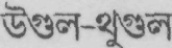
উগুল-থুগুল
